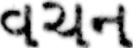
વચન
